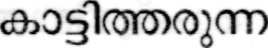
കാട്ടിത്തരുന്ന
